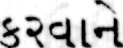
કરવાને
